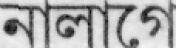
নালাগে
